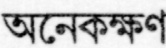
অনেকক্ষণ
